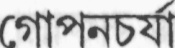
গোপনচর্যা
